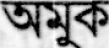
অমুক
